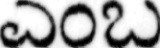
ಎಂಬ
